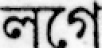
লগে
